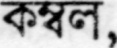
কম্বল,
